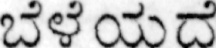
ಬೆಳೆಯದೆ
